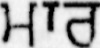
ਮਾਰ
